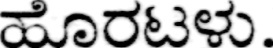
ಹೊರಟಳು.
